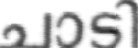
ചാടി
